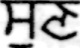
ਸੁਣ
